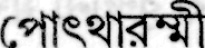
পোৎথারম্মী
